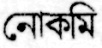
নোকমি
